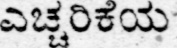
ಎಚ್ಚರಿಕೆಯ
